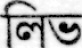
লিভ
